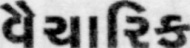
વૈચારિક
